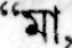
"মা,
